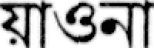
য়াওনা
